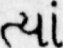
ત્યાં
